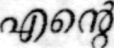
എന്റെ
